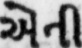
એની
